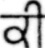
ਕੀ
